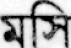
মসি
